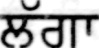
ਲੱਗਾ
